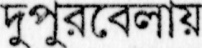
দুপুরবেলায়
